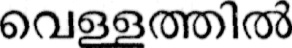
വെള്ളത്തില്‍
